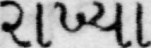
રાખ્યા
